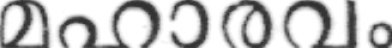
മഹാരവം
